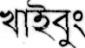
খাইবুং
